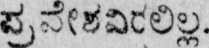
ಪ್ರವೇಶವಿರಲಿಲ್ಲ.
